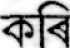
কৰি
